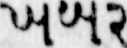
ખબર
